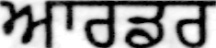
ਆਰਡਰ
